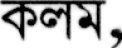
কলম,
